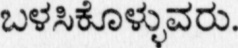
ಬಳಸಿಕೊಳ್ಳುವರು.
